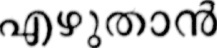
എഴുതാന്‍
